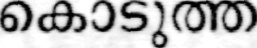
കൊടുത്ത
